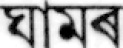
ঘামৰ
